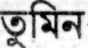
তুমিন
